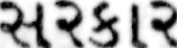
સરકાર
